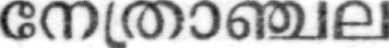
നേത്രാഞ്ചല
